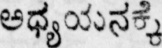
ಅಧ್ಯಯನಕ್ಕೆ
